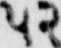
પર
